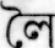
লৈ
